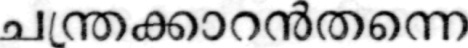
ചന്ത്രക്കാറന്‍തന്നെ
